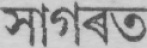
সাগৰত
